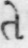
તે
